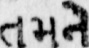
તમને
